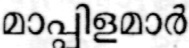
മാപ്പിളമാര്‍
